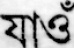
যাওঁ
